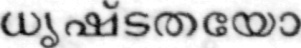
ധൃഷ്ടതയോ
